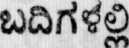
ಬದಿಗಳಲ್ಲಿ
